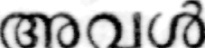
അവള്‍
